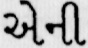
એની
